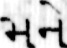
મને
